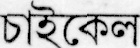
চাইকেল
